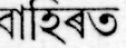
বাহিৰত
